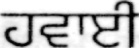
ਹਵਾਈ
